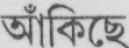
আঁকিছে
